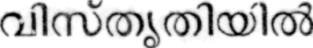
വിസ്തൃതിയില്‍
